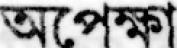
অপেক্ষা
